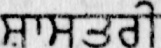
ਸ਼ਾਸਤਰੀ
